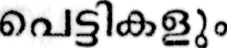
പെട്ടികളും
